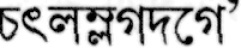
চৎলম্লগদগে’
